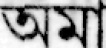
অমা
